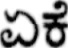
ಏಕೆ
